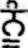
ਨੂੰ
